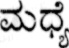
ಮಧ್ಯೆ
